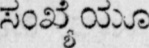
ಸಂಖ್ಯೆಯೂ
